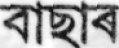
বাছাৰ
